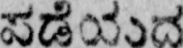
ಪಡೆಯದ
